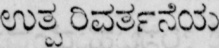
ಉತ್ಪರಿವರ್ತನೆಯ
